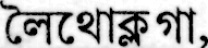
লৈথোক্লগা,
